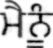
ਮੈਨੂੰ
